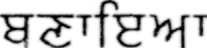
ਬਣਾਇਆ
